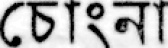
চোংনা
